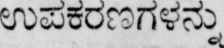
ಉಪಕರಣಗಳನ್ನು
